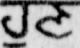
ਹੁਣ
